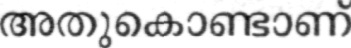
അതുകൊണ്ടാണ്
